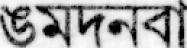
ঙমদনবা
